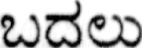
ಬದಲು
